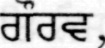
ਗੌਰਵ,
